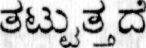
ತಟ್ಟುತ್ತದೆ
